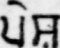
ਪੇਸ਼
